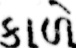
કાળે
